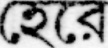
হেরে
